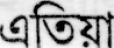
এতিয়া
